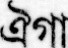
ঐগা
